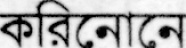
করিনোনে
